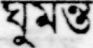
ঘুমন্ত
